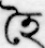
হৈ
